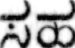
ಸಹ
